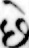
છે
